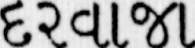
દરવાજા
